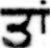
ਤਾਂ
